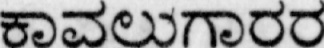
ಕಾವಲುಗಾರರ
